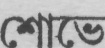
শোভে
